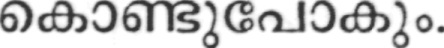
കൊണ്ടുപോകും.
